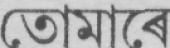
তোমাৰে
